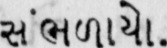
સંભળાયો.
